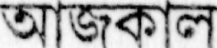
আজকাল
